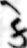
કે
